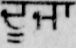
ਦੂਜਾ
